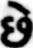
છે
